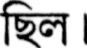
ছিল।
